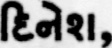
દિનેશ,
